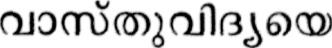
വാസ്തുവിദ്യയെ
